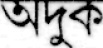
অদুক
